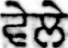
ਵੇਲੇ
